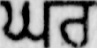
ਘਰ
